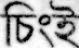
চিংই
